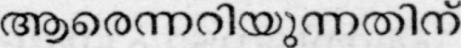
ആരെന്നറിയുന്നതിന്
